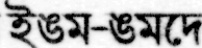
ইঙম-ঙমদে
